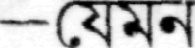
-যেমন
